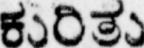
ಕುರಿತು
